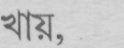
খায়,
